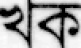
খক
